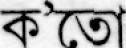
ক'তো
